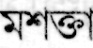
মশক্তা
